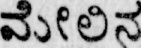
ಮೇಲಿನ
